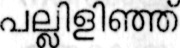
പല്ലിളിഞ്ഞ്
